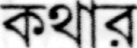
কথার
